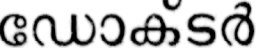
ഡോക്ടര്‍
